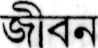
জীবন
